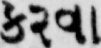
કરવા
